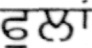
ਫੁਲਾਂ
